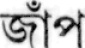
জাঁপ
